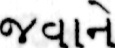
જવાને
